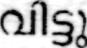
വിട്ടു
